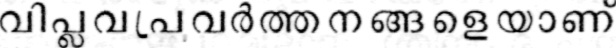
വിപ്ലവപ്രവര്‍ത്തനങ്ങളെയാണ്
